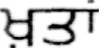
ਖ਼ਤਾਂ
